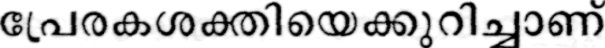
പ്രേരകശക്തിയെക്കുറിച്ചാണ്
